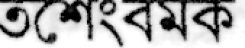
তশেংবমক
